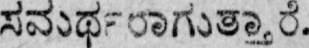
ಸಮರ್ಥರಾಗುತ್ತಾರೆ.
